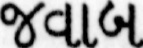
જવાબ
